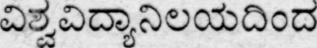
ವಿಶ್ವವಿದ್ಯಾನಿಲಯದಿಂದ
